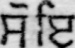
ਸੋਇ
